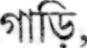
গাড়ি,
